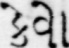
કેવો
